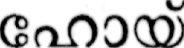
ഹോയ്
